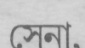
সেনা,
